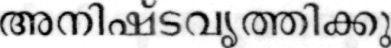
അനിഷ്ടവൃത്തിക്കു
